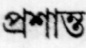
প্রশান্ত
